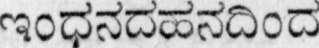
ಇಂಧನದಹನದಿಂದ
